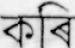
কৰি
